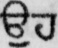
ਉਹ
